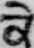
ਕੇ
